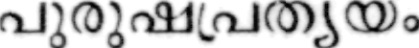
പുരുഷപ്രത്യയം
